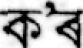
ক'ৰ
